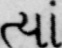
ત્યાં
